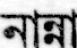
নান্না
